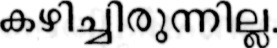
കഴിച്ചിരുന്നില്ല.
